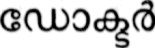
ഡോക്ടര്‍
